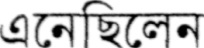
এনেছিলেন
